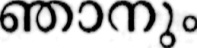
ഞാനും
